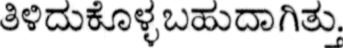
ತಿಳಿದುಕೊಳ್ಳಬಹುದಾಗಿತ್ತು.
